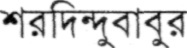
শরদিন্দুবাবুর
